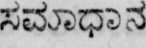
ಸಮಾಧಾನ
